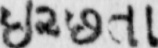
ઇચ્છતા
